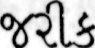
જરીક
